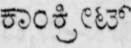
ಕಾಂಕ್ರೀಟ್
